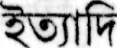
ইত্যাদি
